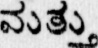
ಮತ್ತು
